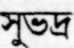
সুভদ্র
